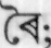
ৰৈ;
